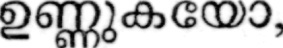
ഉണ്ണുകയോ,
